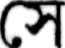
সে
